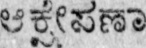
ಆಕ್ಷೇಪಣಾ
